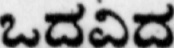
ಒದವಿದ
